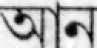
আন
